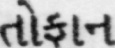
તોફાન
